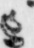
હું
